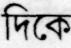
দিকে
